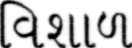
વિશાળ
